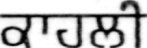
ਕਾਹਲੀ
